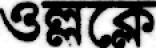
ওল্লক্লে
